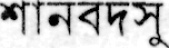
শানবদসু
